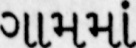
ગામમાં
